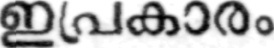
ഇപ്രകാരം
